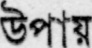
উপায়
